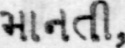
માનતી,
